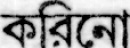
করিনো
